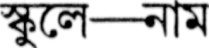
স্কুলে-নাম
